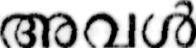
അവള്‍
